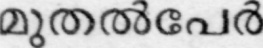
മുതല്‍പേര്‍
